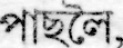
পাছলৈ,
